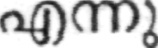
എന്നു
